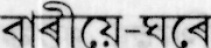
বাৰীয়ে-ঘৰে
